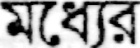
মধ্যের
